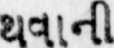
થવાની
